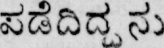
ಪಡೆದಿದ್ದನು
